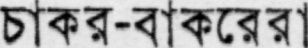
চাকর-বাকরেরা
